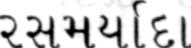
રસમર્યાજા
